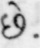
છે.
